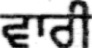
ਵਾਰੀ
